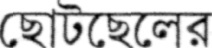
ছোটছেলের
